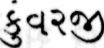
કુંવરજી
